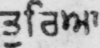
ਤੁਰਿਆ
